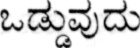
ಒಡ್ಡುವುದು
